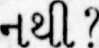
નથી?
